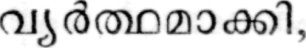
വ്യര്‍ത്ഥമാക്കി,
